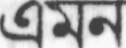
এমন
